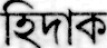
হিদাক
